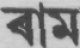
ৰাম
